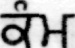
ਕੰਮ
